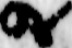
જ
